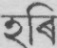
হৰি
